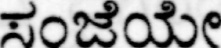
ಸಂಜೆಯೇ
